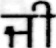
ਜੀ
